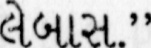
લેબાસ."
